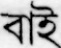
বাই
